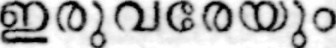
ഇരുവരേയും
